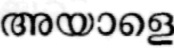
അയാളെ
